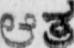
ಆತ
